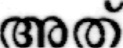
അത്
